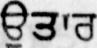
ਉਤਾਰ
